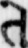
તે
